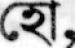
হো,
